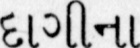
દાગીના
